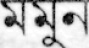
মমুন
